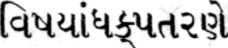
વિષયાંધક્પતરણે
